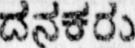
ದನಕರು
